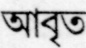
আবৃত
